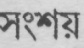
সংশয়
